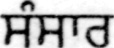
ਸੰਸਾਰ
